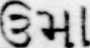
ઉમા
